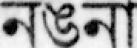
নঙনা
